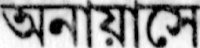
অনায়াসে
